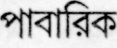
পাবারিক
